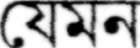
যেমন
